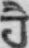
ਹੈ
